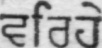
ਵਰਿਹੇ
